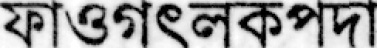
ফাওগৎলকপদা
